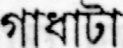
গাধাটা
